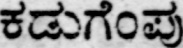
ಕಡುಗೆಂಪು
